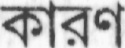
কারণ
